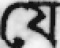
যে
